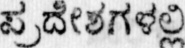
ಪ್ರದೇಶಗಳಲ್ಲಿ
